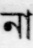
না
